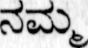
ನಮ್ಮ
